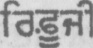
ਰਿਫ਼ੂਜੀ
